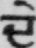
ਦੇ
